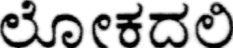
ಲೋಕದಲಿ
